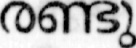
രണ്ടു
